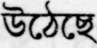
উঠেছে
